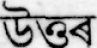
উত্তৰ
